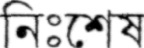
নিঃশেষ
